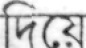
দিয়ে
